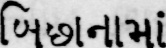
બિછાનામાં
